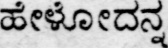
ಹೇಳೋದನ್ನ
